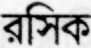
রসিক
